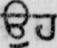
ਉਹ
